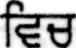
ਵਿਚ
